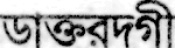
ডাক্তরদগী
